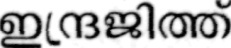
ഇന്ദ്രജിത്ത്
